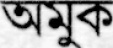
অমুক
